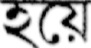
হয়ে
